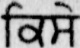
ਕਿਸੇ
